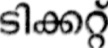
ടിക്കറ്റ്
